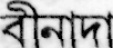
বীনাদা
